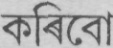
কৰিবো
